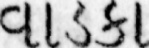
વાડકા
